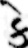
કે
